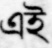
এই
